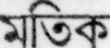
মতিক
